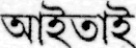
আইতাই
